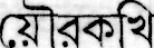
য়ৌরকখি
